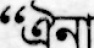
“ঐনা
